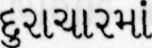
દુરાચારમાં
